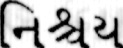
નિશ્ચય
